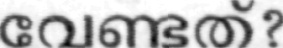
വേണ്ടത്?
